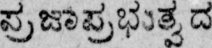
ಪ್ರಜಾಪ್ರಭುತ್ವದ
